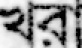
খরা
